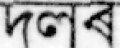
দলৰ
